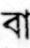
বা
